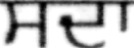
ਸਦਾ
